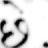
છે.
